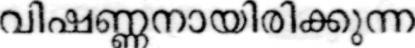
വിഷണ്ണനായിരിക്കുന്ന
